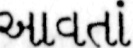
આવતાં
